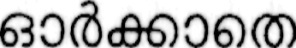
ഓര്‍ക്കാതെ
